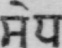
ਸੇਧ
